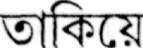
তাকিয়ে
